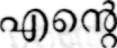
എന്റെ
